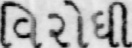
વિરોધી
